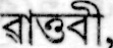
ৱাত্তবী,
